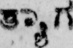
ತ್ಯಾಗ
